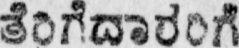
ತೆರಿಗೆದಾರರಿಗೆ
